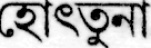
হোৎতুনা
